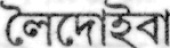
লৈদোইবা
